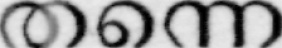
തന്നെ
